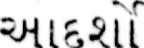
આદર્શો
